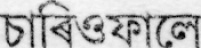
চাৰিওফালে
